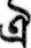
ঐ
